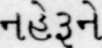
નહેરૂને
